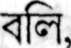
বলি,
